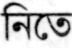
নিতে
